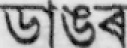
ডাঙৰ
